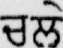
ਚਲੇ
